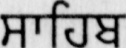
ਸਾਹਿਬ
